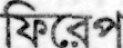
ফিরেপ
